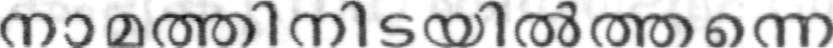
നാമത്തിനിടയില്‍ത്തന്നെ
